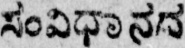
ಸಂವಿಧಾನದ
